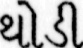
થોડી
